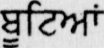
ਬੂਟਿਆਂ
